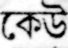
কেউ
